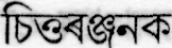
চিত্তৰঞ্জনক
